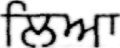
ਲਿਆ
